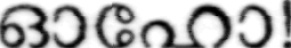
ഓഹോ!
